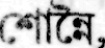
শোন্নৈ,
